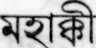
মহাক্কী
